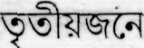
তৃতীয়জনে
